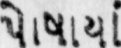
પોષાયાં
